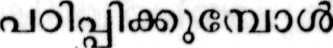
പഠിപ്പിക്കുമ്പോള്‍
